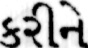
કરીને
